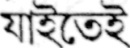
যাইতেই
